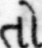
તો
